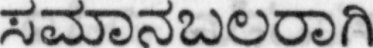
ಸಮಾನಬಲರಾಗಿ
